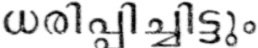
ധരിപ്പിച്ചിട്ടും
